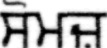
ਸੋਮਜ਼
